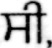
ਸੀ,
